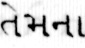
તેમના
